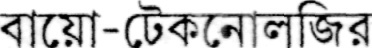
বায়ো-টেকনোলজির
